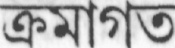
ক্রমাগত
